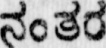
ನಂತರ
